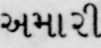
અમારી
